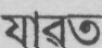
যাৱত
